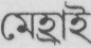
মেহ্ৰাই
